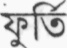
ফুর্তি
